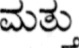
ಮತ್ತು
